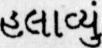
હલાવ્યું
